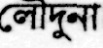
লৌদুনা
